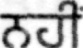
ਨਹੀਂ
